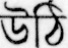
উঠি
